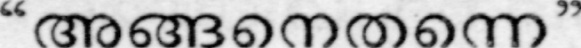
"അങ്ങനെതന്നെ"
